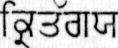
ਕ੍ਰਿਤੱਗਯ
